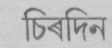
চিৰদিন
